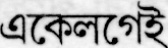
একেলগেই
